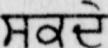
ਸਕਦੇ
